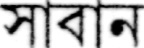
সাবান
